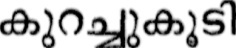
കുറച്ചുകൂടി
